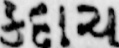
કદાચ
